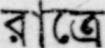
রাত্রে
